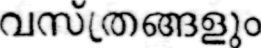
വസ്ത്രങ്ങളും
